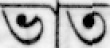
ভাত
